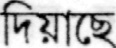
দিয়াছে
